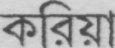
করিয়া
